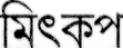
মিৎকপ
